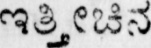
ಇತ್ತೀಚಿನ
